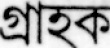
গ্রাহক
